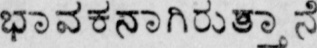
ಭಾವಕನಾಗಿರುತ್ತಾನೆ
